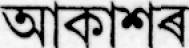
আকাশৰ
